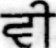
ਵੀ
